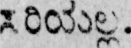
ಸರಿಯಲ್ಲ.
